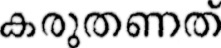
കരുതണത്
